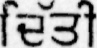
ਦਿੱਤੀ
